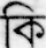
কি
